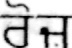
ਰੋਜ਼
